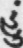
હું
